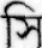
সি
